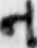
ન
